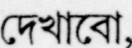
দেখাবো,
